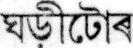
ঘড়ীটোৰ
